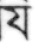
যি
